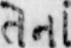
તેનાં
